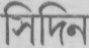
সিদিন
